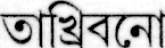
তাখ্রিবনো
